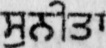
ਸੁਨੀਤਾ
